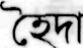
হৈদা
